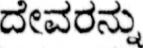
ದೇವರನ್ನು
